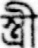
স্ত্রী
